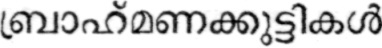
ബ്രാഹ്മണക്കുട്ടികള്‍
